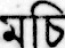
মচি
